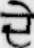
ਦੇ
